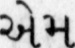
એમ
